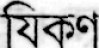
যিকণ
